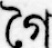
গৈ
